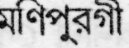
মণিপুরগী
